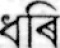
ধৰি
